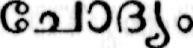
ചോദ്യം
